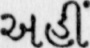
અહીં
